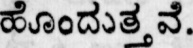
ಹೊಂದುತ್ತವೆ.
